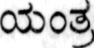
ಯಂತ್ರ
